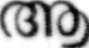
ആ
